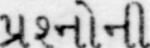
પ્રશ્નોની
